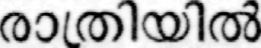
രാത്രിയില്‍
